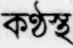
কণ্ঠস্থ
